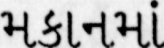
મકાનમાં
